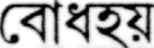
বোধহয়
